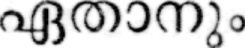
ഏതാനും
